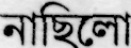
নাছিলো
